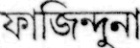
ফাজিন্দুনা
